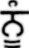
ਨੂੰ
